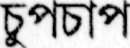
চুপচাপ
